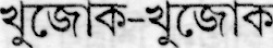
খুজোক-খুজোক
